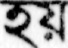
হয়
